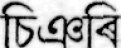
চিঞৰি
